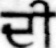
ਦੀ
